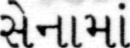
સેનામાં
